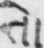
તો
